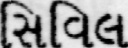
સિવિલ
